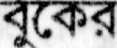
বুকের
